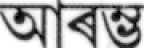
আৰম্ভ
